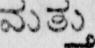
ಮತ್ತು
